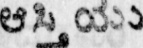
ಆಸ್ತಿಯು
